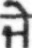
ਜੇ
